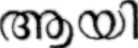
ആയി
